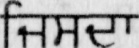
ਜਿਸਦਾ
